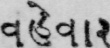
વહેવાર
